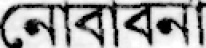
নোবাবনা
